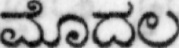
ಮೊದಲ
